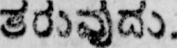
ತರುವುದು.
